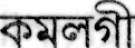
কমলগী
